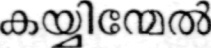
കയ്യിന്മേല്‍
